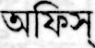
অফিস্
